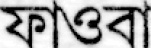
ফাওবা
